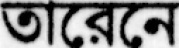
তারেনে
